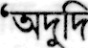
‘অদুদি
